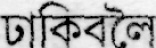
ঢাকিবলৈ
